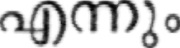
എന്നും
